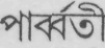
পাৰ্ব্বতী
